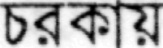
চরকায়
